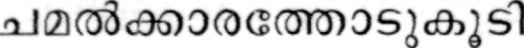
ചമല്‍ക്കാരത്തോടുകൂടി
